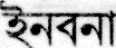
ইনবনা
